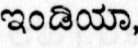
ಇಂಡಿಯಾ,
